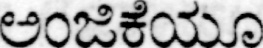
ಅಂಜಿಕೆಯೂ
